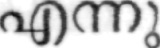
എന്നു
